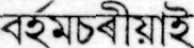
বর্হমচৰীয়াই
